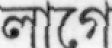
লাগে
